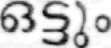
ഒട്ടും
